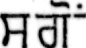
ਸਗੋਂ
